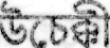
উচেক্কী
